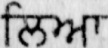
ਲਿਆ
